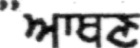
''ਆਥਣ
